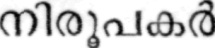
നിരൂപകര്‍
